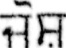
ਜੋਸ਼
